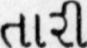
તારી
